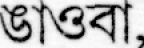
ঙাওবা,
